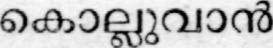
കൊല്ലുവാന്‍
